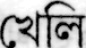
খেলি
